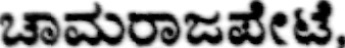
ಚಾಮರಾಜಪೇಟೆ,
